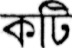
কটি
